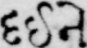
દઈને
